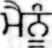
ਮੈਨੂੰ
